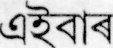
এইবাৰ
